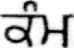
ਕੰਮ
